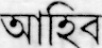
আহিব
